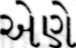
એણે
